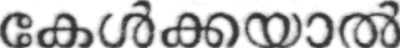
കേള്‍ക്കയാല്‍
